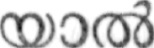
യാല്‍
